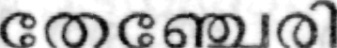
തേഞ്ചേരി
